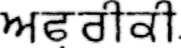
ਅਫ਼ਰੀਕੀ
